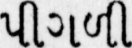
પીગળી
